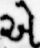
એ
